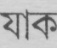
যাক
